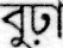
বুঢ়া
